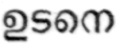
ഉടനെ
